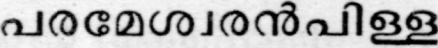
പരമേശ്വരന്‍പിള്ള
